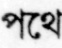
পথে
